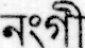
নংগী
